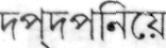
দপ্‌দপনিয়ে
